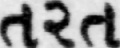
તરત
